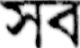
সব
